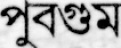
পুবগুম
